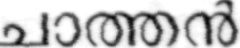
ചാത്തന്‍
